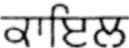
ਕਾਇਲ
